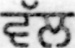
ਵੱਲ
